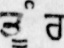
ਤੂੰਰ
